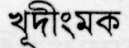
খূদীংমক
